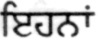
ਇਹਨਾਂ
